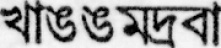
খাঙঙমদ্রবা
